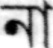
না
